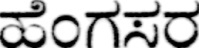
ಹೆಂಗಸರ
